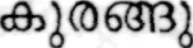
കുരങ്ങു
